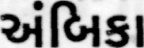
અંબિકા
